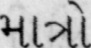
માત્રો
